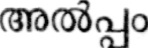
അല്‍പ്പം
